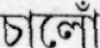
চালোঁ
